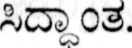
ಸಿದ್ಧಾಂತ.
